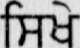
ਸਿਖੇ
